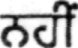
ਨਹੀਂ
